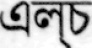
এলচ
